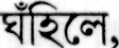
ঘঁহিলে,
